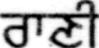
ਰਾਣੀ
